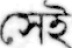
সেই
